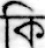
কি
